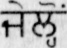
ਜੇਲ੍ਹੋਂ
